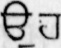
ਉਹ
